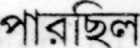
পারছিল
